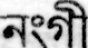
নংগী
